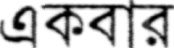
একবার
